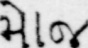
મોજ
